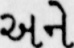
અને
